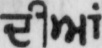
ਦੀਆਂ
